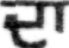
ਦਾ
